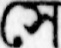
সে
